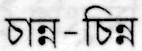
চান্ন-চিন্ন
